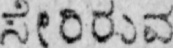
ಸೇರಿರುವ
